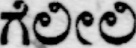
ಗೆಲೀಲಿ
